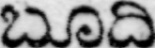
ಬೂದಿ
